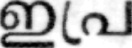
ഇപ്ര
